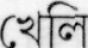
খেলি
